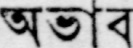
অভাব
